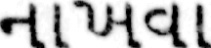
નાખવા
